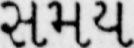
સમય
